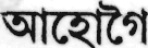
আহোগৈ
